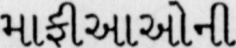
માફીઆઓની
